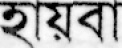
হায়বা
